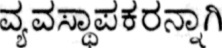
ವ್ಯವಸ್ಥಾಪಕರನ್ನಾಗಿ
